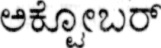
ಅಕ್ಟೋಬರ್
